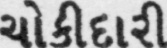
ચોકીદારી
